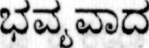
ಭವ್ಯವಾದ
